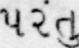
પરંતુ
